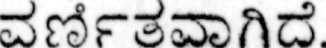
ವರ್ಣಿತವಾಗಿದೆ.
